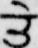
ਤੇ
